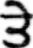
ਤੇ
